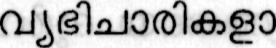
വ്യഭിചാരികളാ
